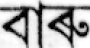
বাৰু
